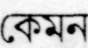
কেমন
